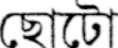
ছোটো
